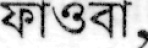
ফাওবা,
